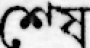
শেষ
